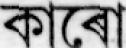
কাৰো
